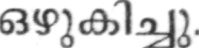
ഒഴുകിച്ചു.
